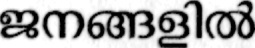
ജനങ്ങളില്‍
